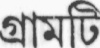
গ্রামটি
